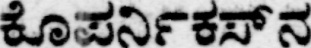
ಕೊಪರ್ನಿಕಸ್‌ನ
